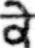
ਕੇ
